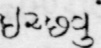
ઇચ્છવું
